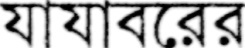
যাযাবরের
